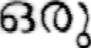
ഒരു
